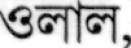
ওলাল,
